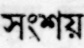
সংশয়
